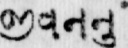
જીવનનું
